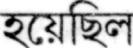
হয়েছিল
